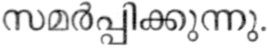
സമര്‍പ്പിക്കുന്നു.
